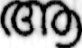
ആ
